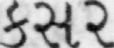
કસર
